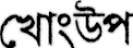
খোংউপ
